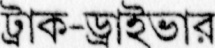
ট্রাক-ড্রাইভার
